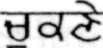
ਚੁਕਣੇ
